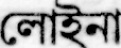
লোইনা
